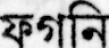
ফগনি
